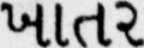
ખાતર
